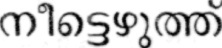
നീട്ടെഴുത്ത്
